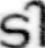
ടി
